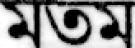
মতম
